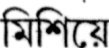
মিশিয়ে
